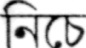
নিচে
